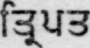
ਤ੍ਰਿਪਤ
